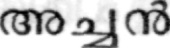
അച്ചന്‍
